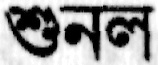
শুনল
